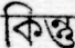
কিন্তু
